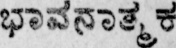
ಭಾವನಾತ್ಮಕ
